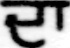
ਦਾ
